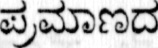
ಪ್ರಮಾಣದ
